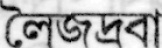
লৈজদ্রবা
